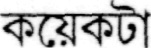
কয়েকটা
